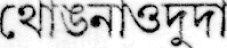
থোঙনাওদুদা
